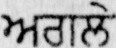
ਅਗਲੇ
